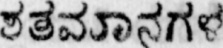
ಶತಮಾನಗಳ
